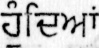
ਹੁੰਦਿਆਂ
